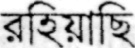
রহিয়াছি
